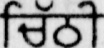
ਚਿੱਠੀ
